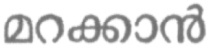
മറക്കാന്‍
